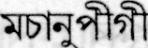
মচানুপীগী
